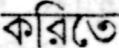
করিতে
